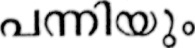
പന്നിയും
